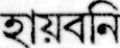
হায়বনি
